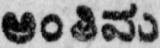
ಅಂತಿಮ
